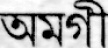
অমগী
